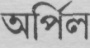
অৰ্পিল
